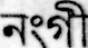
নংগী
